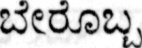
ಬೇರೊಬ್ಬ
